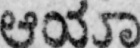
ಆಯಾ
